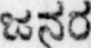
ಜನರ
